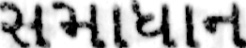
સમાધાન
